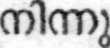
നിന്നു
